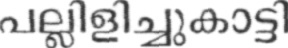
പല്ലിളിച്ചുകാട്ടി
